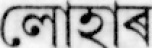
লোহাৰ
